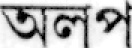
অলপ
